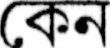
কেন
